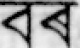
বৰ
